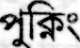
পুক্নিং
